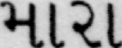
મારા
